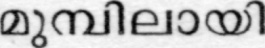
മുമ്പിലായി
